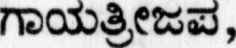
ಗಾಯತ್ರೀಜಪ,
